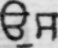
ਉਸ
